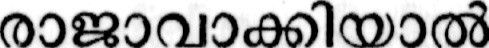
രാജാവാക്കിയാല്‍
